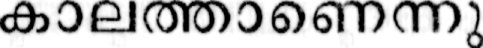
കാലത്താണെന്നു
